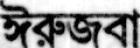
ঈরুজবা
